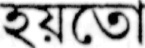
হয়তো
